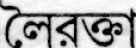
লৈরক্তা
